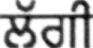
ਲੱਗੀ
